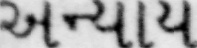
અન્યાય
